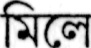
মিলে
